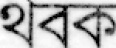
থবক
